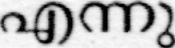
എന്നു
